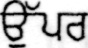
ਉੱਪਰ
